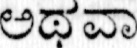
ಅಥವಾ
